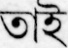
তাই
